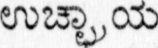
ಉಚ್ಛ್ರಾಯ
